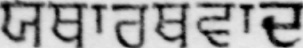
ਯਥਾਰਥਵਾਦ
